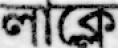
লাক্লে
